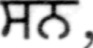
ਸਨ,
